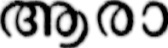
ആരാ
